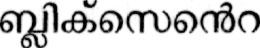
ബ്ലിക്സെന്റെ
